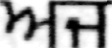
ਅਜ
